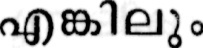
എങ്കിലും
